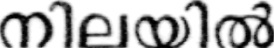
നിലയില്‍
